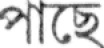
পাছে
